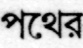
পথের
